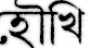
হৌখি
